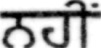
ਨਹੀਂ
